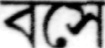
বসে
